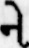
ને
